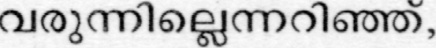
വരുന്നില്ലെന്നറിഞ്ഞ്,
